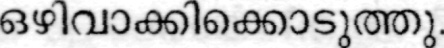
ഒഴിവാക്കിക്കൊടുത്തു.
